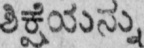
ಶಿಕ್ಷೆಯನ್ನು
